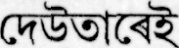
দেউতাৰেই
